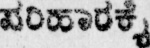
ಪರಿಹಾರಕ್ಕೆ
